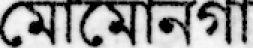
মোমোনগা
